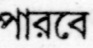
পারবে
